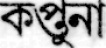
কপ্তুনা
